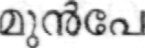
മുന്‍പേ
